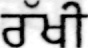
ਰੱਖੀ
